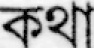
কথা
